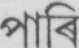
পাৰি
